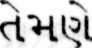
તેમણે
